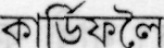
কার্ডিফলৈ
